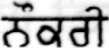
ਨੌਕਰੀ
